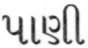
પાણી
